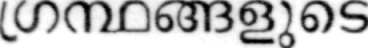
ഗ്രന്ഥങ്ങളുടെ
